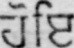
ਹੋਇ
